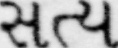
સત્ય
